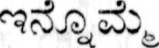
ಇನ್ನೊಮ್ಮೆ
